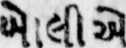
બોલીએ
